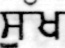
ਸੁੱਖ
